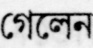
গেলেন
